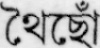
থৈছোঁ
